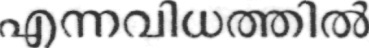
എന്നവിധത്തില്‍
